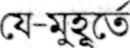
যে-মুহূর্তে
